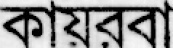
কায়রবা
